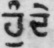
ਹੁੰਦੇ
